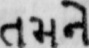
તમને
